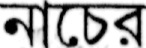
নাচের
